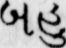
બહુ
